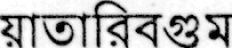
য়াতিরিবগুম
